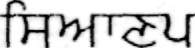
ਸਿਆਣਪ
